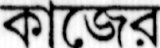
কাজের
